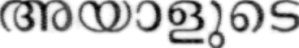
അയാളുടെ
